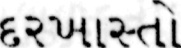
દરખાસ્તો
